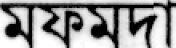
মফমদা
